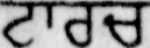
ਟਾਰਚ
